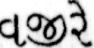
વજીરે
